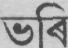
ভৰি
